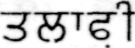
ਤਲਾਫ਼ੀ
